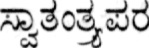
ಸ್ವಾತಂತ್ರ್ಯಪರ
